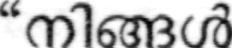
“നിങ്ങള്‍
